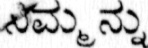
ನಮ್ಮನ್ನು
